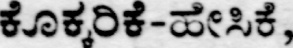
ಕೊಕ್ಕರಿಕೆ-ಹೇಸಿಕೆ,
